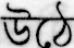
উঠে
